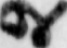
જ
